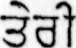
ਤੇਰੀ
